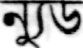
ন্যুড
